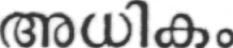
അധികം
